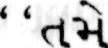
"તમે
